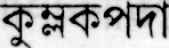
কুম্লকপদা
